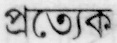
প্রত্যেক
